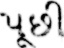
પૂછી
